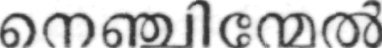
നെഞ്ചിന്മേല്‍
